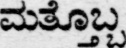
ಮತ್ತೊಬ್ಬ
